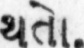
થતો.
